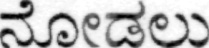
ನೋಡಲು
